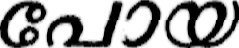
പോയ
